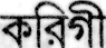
করিগী
